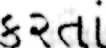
કરતાં
